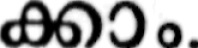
ക്കാം.
